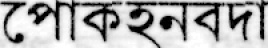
পোকহনবদা
